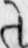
તે
